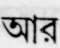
আর
